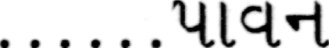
......પાવન
